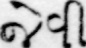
જેવી
